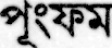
পূংফম
